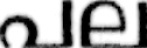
പല
